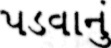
પડવાનું
